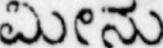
ಮೀನು
